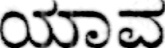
ಯಾವ
